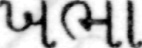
ખભા
